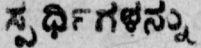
ಸ್ಪರ್ಧಿಗಳನ್ನು
